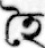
হৈ
